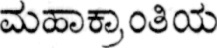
ಮಹಾಕ್ರಾಂತಿಯ
